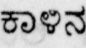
ಕಾಳಿನ
